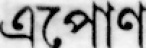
এপোণ
